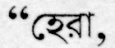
“হেরা,
